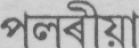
পলৰীয়া
